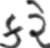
કરે
